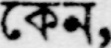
কেন,
